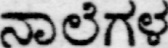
ನಾಲೆಗಳ
